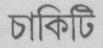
চাকিটি
